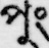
পুং
